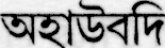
অহাউবদি
